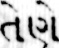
તેણે
